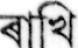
ৰাখি
